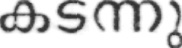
കടന്നു
